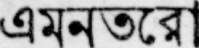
এমনতরো
